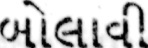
બોલાવી
